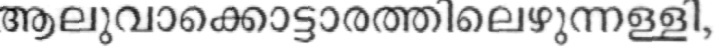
ആലുവാക്കൊട്ടാരത്തിലെഴുന്നള്ളി,
